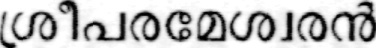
ശ്രീപരമേശ്വരന്‍
